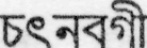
চৎনবগী
